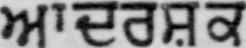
ਆਦਰਸ਼ਕ
